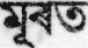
মূৰত
